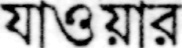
যাওয়ার
